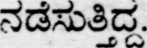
ನಡೆಸುತ್ತಿದ್ದ.
